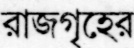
রাজগৃহের
